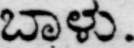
ಬಾಳು.
